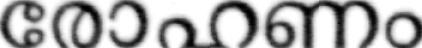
രോഹണം
